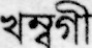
খম্বগী
